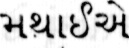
મથાઈએ
